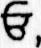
ਓ,
